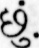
છું.
